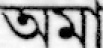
অমা
